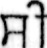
ਸੀ
